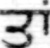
ਤਾਂ
